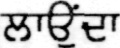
ਲਾਉਂਦਾ
